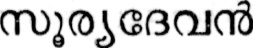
സൂര്യദേവന്‍
